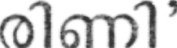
രിണി'
